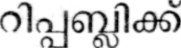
റിപ്പബ്ലിക്ക്
